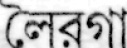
লৈরগা
